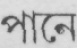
পানে
